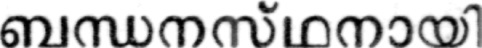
ബന്ധനസ്ഥനായി
